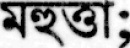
মহুত্তা;
